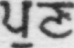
ਪੁਣ
